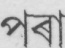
পৰা
